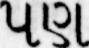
પણ
